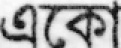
একো
